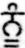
ਨੂੰ
